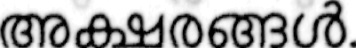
അക്ഷരങ്ങള്‍.
